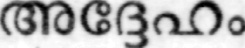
അദ്ദേഹം
